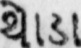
થોડા
